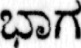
ಭಾಗ
